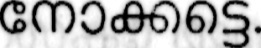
നോക്കട്ടെ.
